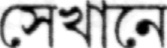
সেখানে
